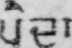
ਪੈਦਾ
